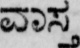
ವಾಸ್ತ
